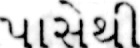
પાસેથી
